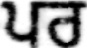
ਪਰ
